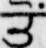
ਤੋਂ
